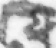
যে
